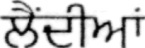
ਲੈਂਦੀਆਂ
